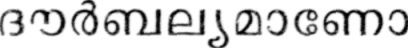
ദൌര്‍ബല്യമാണോ
